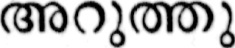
അറുത്തു
